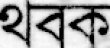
থবক
